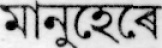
মানুহেৰে
